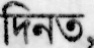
দিনত,
